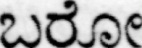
ಬರೋ
